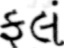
ફલં
